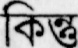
কিন্তু
